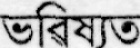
ভৱিষ্যত
